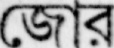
জোর
